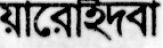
য়ারোইদবা
